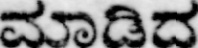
ಮಾಡಿದ
